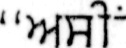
''ਅਸੀਂ
